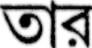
তার
